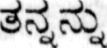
ತನ್ನನ್ನು
